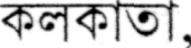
কলকাতা,
